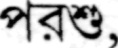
পরশু,
